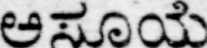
ಅಸೂಯೆ
